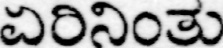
ಏರಿನಿಂತು
